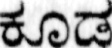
ಕೂಡ
